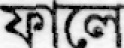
ফালে
